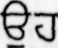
ਉਹ
